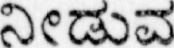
ನೀಡುವ
